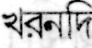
খরনদি
